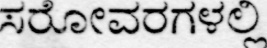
ಸರೋವರಗಳಲ್ಲಿ
